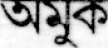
অমুক
